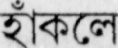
হাঁকলে
